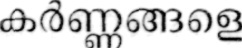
കര്‍ണ്ണങ്ങളെ
